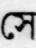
সে
